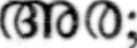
അര;
